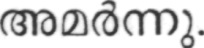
അമര്‍ന്നു.
